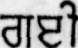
ਗਈ
